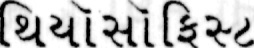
થિયૉસૉફિસ્ટ
